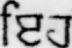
ਇਹ
